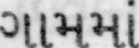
ગામમાં
